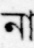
না
